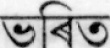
ভৰিত
